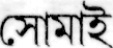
সোমাই
